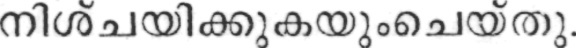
നിശ്ചയിക്കുകയുംചെയ്തു.
